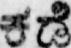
ಕಡೆ
